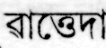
ৱাত্তেদা
